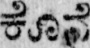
ಕೊವೆ
